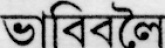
ভাবিবলৈ
